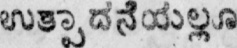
ಉತ್ಪಾದನೆಯಲ್ಲೂ
